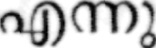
എന്നു
